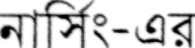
নার্সিং-এর
